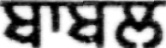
ਬਾਬਲ
